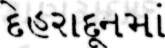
દેહરાદૂનમાં
